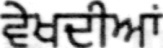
ਵੇਖਦੀਆਂ
